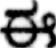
ಈ
